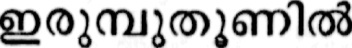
ഇരുമ്പുതൂണില്‍
